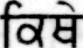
ਕਿਥੇ
